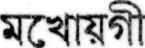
মখোয়গী
